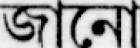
জানো
